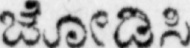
ಜೋಡಿಸಿ
